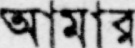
আমার
